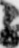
કે
